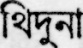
থিদুনা
